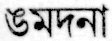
ঙমদনা
